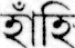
হাঁহি
